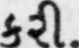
કરી.
